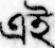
এই
